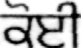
ਕੋਈ
